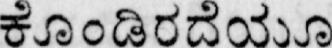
ಕೊಂಡಿರದೆಯೂ
